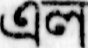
এল
